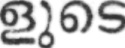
ളുടെ
